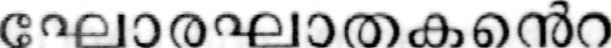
ഘോരഘാതകന്റെ
